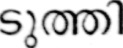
ടുത്തി
